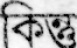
কিন্তু
